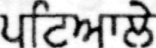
ਪਟਿਆਲੇ
